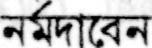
নর্মদাবেন
